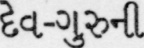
દેવ-ગુરુની
